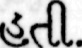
હતી.
